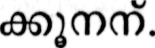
ക്കൂനന്.
